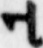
ન
